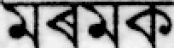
মৰমক
